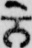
ਨੇ
